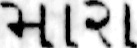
મારા
